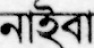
নাইবা
